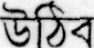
উঠিব
